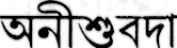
অনীশুবদা
